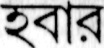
হবার
